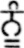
ਨੂੰ
